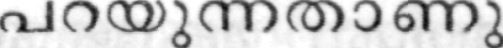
പറയുന്നതാണു
